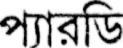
প্যারডি
